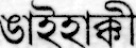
ঙাইহাক্কী
